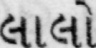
લાલો
